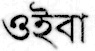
ওইবা
